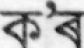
ক'ৰ
